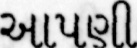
આપણી
